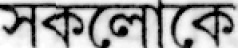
সকলোকে
